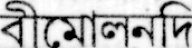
বীমোলনদি
